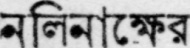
নলিনাক্ষের
